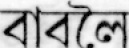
বাবলৈ
